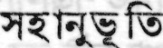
সহানুভূতি
